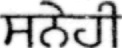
ਸਨੇਹੀ
